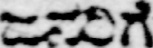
ಜನರಿಗೆ
